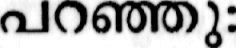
പറഞ്ഞു:
